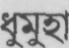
ধুমুহা
